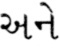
અને
